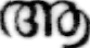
ആ
